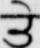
ਤੇ
